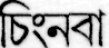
চিংনবা
